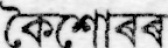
কৈশোৰৰ
